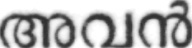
അവന്‍
